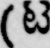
(ಟ
